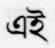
এই
